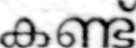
കണ്ട്
